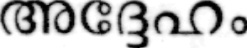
അദ്ദേഹം
